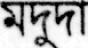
মদুদা
